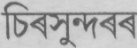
চিৰসুন্দৰৰ
